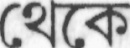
থেকে
